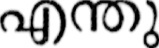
എന്തു
